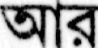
আর
